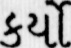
કર્યો
